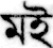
মই
